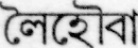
লৈহৌবা
